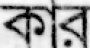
কার
